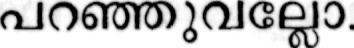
പറഞ്ഞുവല്ലോ.
